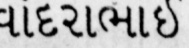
વાંદરાભાઈ
